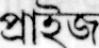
প্রাইজ
